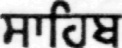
ਸਾਹਿਬ
